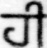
ਹੀ
